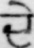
ਦੇ
